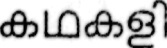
കഥകളി
